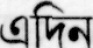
এদিন
